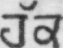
ਹੱਕ
